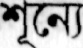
শূন্যে
